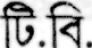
টি.বি.
